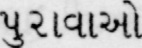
પુરાવાઓ
